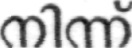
നിന്ന്
